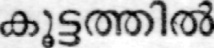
കൂട്ടത്തില്‍
